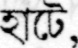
হাটে,
